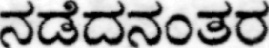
ನಡೆದನಂತರ
